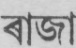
ৰাজা
